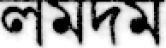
লমদম
